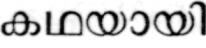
കഥയായി
